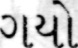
ગયો
